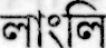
লাংলি
